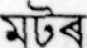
মটৰ
